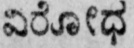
ವಿರೋಧ
